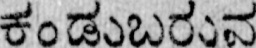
ಕಂಡುಬರುವ
